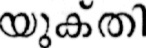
യുക്തി
